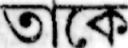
তাকে
